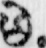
છે.
